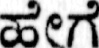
ಹೇಗೆ
